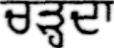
ਚੜ੍ਹਦਾ
